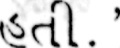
હતી.'
